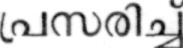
പ്രസരിച്ച്
